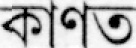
কাণত
